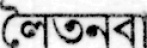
লৈতনবা
